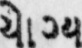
યોગ્ય
